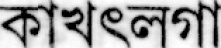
কাখৎলগা
